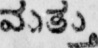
ಮತ್ತು
